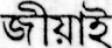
জীয়াই
